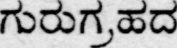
ಗುರುಗ್ರಹದ
